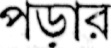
পড়ার
